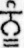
ਨੂੰ
